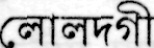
লোলদগী
